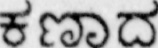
ಕಣಾದ
